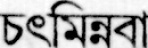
চৎমিন্নবা
